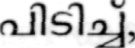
പിടിച്ച്,
